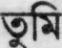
তুমি
